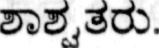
ಶಾಶ್ವತರು.
